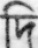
দি
